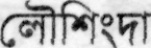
লৌশিংদা
